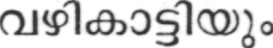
വഴികാട്ടിയും
